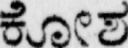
ಕೋಶ
